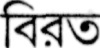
বিরত
